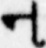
ન
